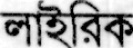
লাইরিক
